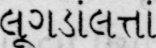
લૂગડાંલત્તાં
